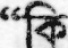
"কি
